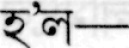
হ'ল-
